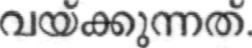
വയ്ക്കുന്നത്.
